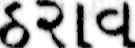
ઠરાવ
